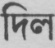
দিল
